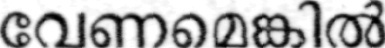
വേണമെങ്കില്‍
